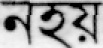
নহয়
